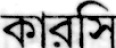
কারসি
